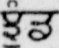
ਝੁੰਡ
